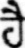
ਹੈ
